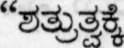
“ಶತ್ರುತ್ವಕ್ಕೆ
